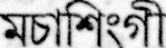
মচাশিংগী
